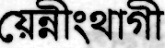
য়েন্নীংথাগী
